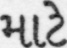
માટે
